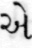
એ
